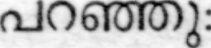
പറഞ്ഞു:
